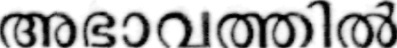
അഭാവത്തില്‍
